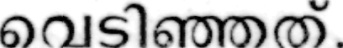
വെടിഞ്ഞത്.
